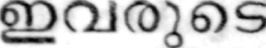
ഇവരുടെ
